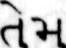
તેમ
